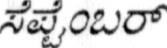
ಸೆಪ್ಟೆಂಬರ್
